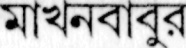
মাখনবাবুর
